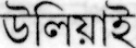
উলিয়াই
